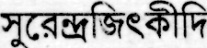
সুরেন্দ্রজিৎকীদি
